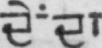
ਦੇਂਦਾ
